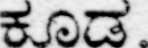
ಕೂಡ.
